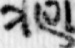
ત્રણ
